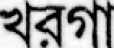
খরগা
